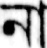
না
